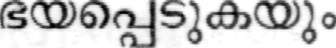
ഭയപ്പെടുകയും
